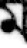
ম
